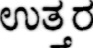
ಉತ್ತರ
